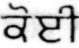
ਕੋਈ
